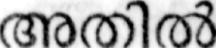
അതില്‍
